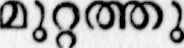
മുറ്റത്തു
